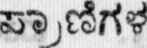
ಪ್ರಾಣಿಗಳ
